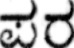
ಪರ
